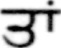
ਤਾਂ
